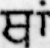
ਥਾਂ
